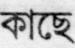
কাছে
